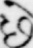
છે
